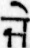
ਜੇ
